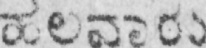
ಹಲವಾರು
